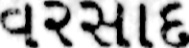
વરસાદ
